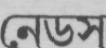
নেডস
